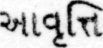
આવૃત્તિ
